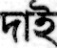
দাই
